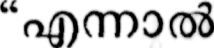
“എന്നാല്‍
